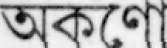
অকণো
